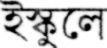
ইস্কুলে
